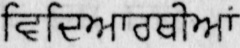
ਵਿਦਿਆਰਥੀਆਂ
